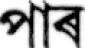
পাৰ
